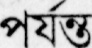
পর্যন্ত
